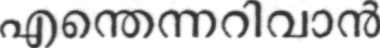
എന്തെന്നറിവാന്‍
